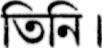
তিনি।
